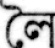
লৈ
